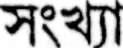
সংখ্যা
